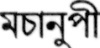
মচানুপী
